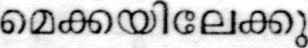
മെക്കയിലേക്കു
